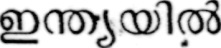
ഇന്ത്യയില്‍
